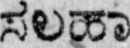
ಸಲಹಾ
